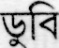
ডুবি
